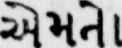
એમનો
